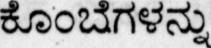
ಕೊಂಬೆಗಳನ್ನು
